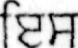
ਇਸ
